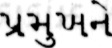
પ્રમુખને
